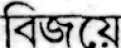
বিজয়ে
